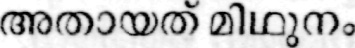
അതായത്മിഥുനം
